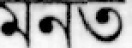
মনত
